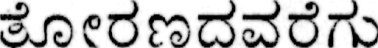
ತೋರಣದವರೆಗು
